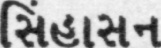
સિંહાસન
